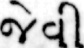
જેવી
